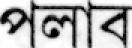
পলাব
